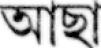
আছা
